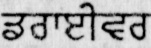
ਡਰਾਈਵਰ
